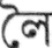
লৈ
